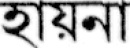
হায়না
